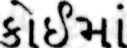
કોઈમાં
